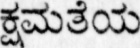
ಕ್ಷಮತೆಯ
